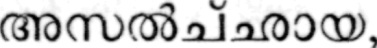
അസല്‍ച്ഛായ,
